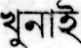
খুনাই
